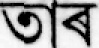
তাৰ
